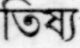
তিষ্য
